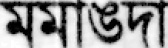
মমাঙদা
